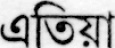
এতিয়া
